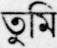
তুমি
